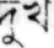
দুখ
